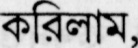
করিলাম,
